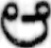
ಆ
